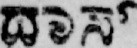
ದಾಸ್
